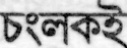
চংলকই
